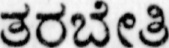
ತರಬೇತಿ
